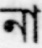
না
